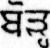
ਬੋੜ੍ਹ
